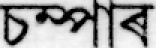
চম্পাৰ
